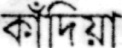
কাঁদিয়া
